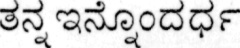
ತನ್ನಇನ್ನೊಂದರ್ಧ
